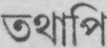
তথাপি
